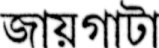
জায়গাটা
